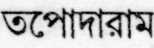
তপোদারাম
